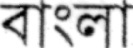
বাংলা
